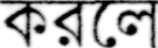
করলে
